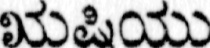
ಋಷಿಯು
